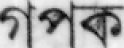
গপক
